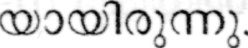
യായിരുന്നു.
